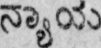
ನ್ಯಾಯ
